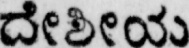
ದೇಶೀಯ
